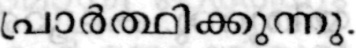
പ്രാര്‍ത്ഥിക്കുന്നു.
